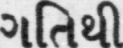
ગતિથી
